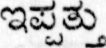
ಇಪ್ಪತ್ತು
